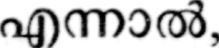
എന്നാല്‍,
